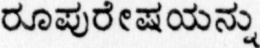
ರೂಪುರೇಷಯನ್ನು
